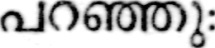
പറഞ്ഞു:
